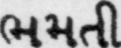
ભમતી
